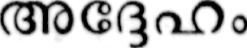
അദ്ദേഹം
